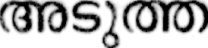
അടുത്ത
